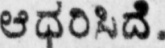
ಆಧರಿಸಿದೆ.
